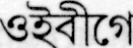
ওইবীগে
